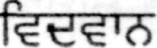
ਵਿਦਵਾਨ
